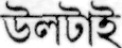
উলটাই
